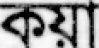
কয়া
